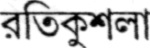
রতিকুশলা
